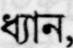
ধ্যান,
